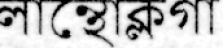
লান্থোক্লগা
